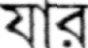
যার
